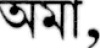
অমা,
